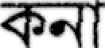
কনা
